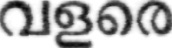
വളരെ
